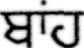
ਬਾਂਹ
